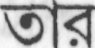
তার
